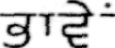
ਭਾਵੇਂ
